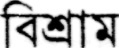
বিশ্রাম
